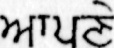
ਆਪਣੇ
